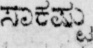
ಸಾಕಷ್ಟು
